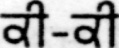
ਕੀ-ਕੀ
